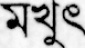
মখুৎ
